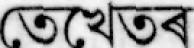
তেখেতৰ
